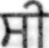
ਸੀ
